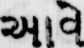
આવે
